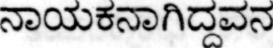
ನಾಯಕನಾಗಿದ್ದವನ
